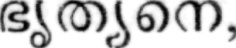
ഭൃത്യനെ,
